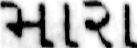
મારા
